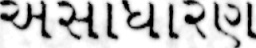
અસાધારણ
